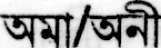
অমা/অনী
